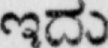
ಇದು
